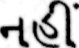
નહીં
